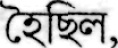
হৈছিল,
